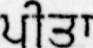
ਪੀਤਾ
